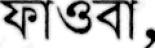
ফাওবা,
